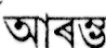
আৰম্ভ
